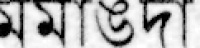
মমাঙদা
